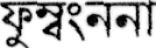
ফুম্বংননা
